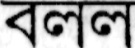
বলল
